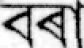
বৰা
